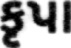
કૃપા
